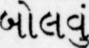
બોલવું
